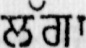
ਲੱਗਾ
